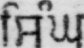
ਸਿੰਘ
